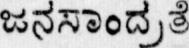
ಜನಸಾಂದ್ರತೆ
